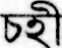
চহী
